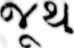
જૂથ
